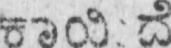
ಕಾಯಿದೆ
